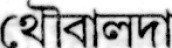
থৌবালদা
